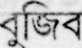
বুজিব
